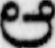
ಆ
